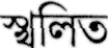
স্খলিত
